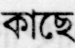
কাছে
